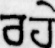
ਰਹੇ
